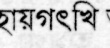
হায়গৎখি
